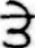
ਤੇ
